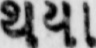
થયા
